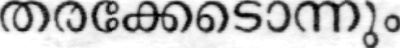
തരക്കേടൊന്നും
